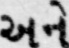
અને
